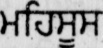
ਮਹਿਸੂਸ
